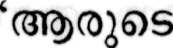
‘ആരുടെ
